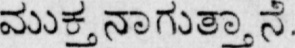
ಮುಕ್ತನಾಗುತ್ತಾನೆ.
